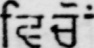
ਵਿਚੋਂ
